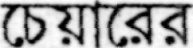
চেয়ারের
